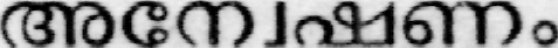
അന്വേഷണം
